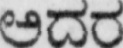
ಅದರ
